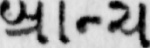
બ્રાન્ચ
